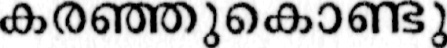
കരഞ്ഞുകൊണ്ടു
